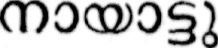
നായാട്ടു
